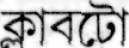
ক্লাবটো
